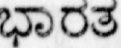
ಭಾರತ
